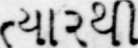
ત્યારથી
